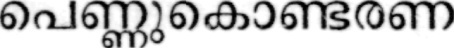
പെണ്ണുകൊണ്ടരണ
